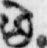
છે.
